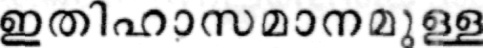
ഇതിഹാസമാനമുള്ള
